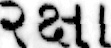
રક્ષા
